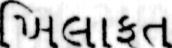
ખિલાફત
